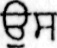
ਉਸ
